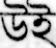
উই
